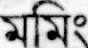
মমিং
